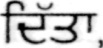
ਦਿੱਤਾ,
